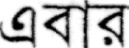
এবার
